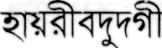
হায়রীবদুদগী
